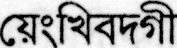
য়েংখিবদগী
